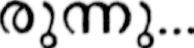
രുന്നു...
